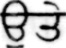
ਉਤੇ
